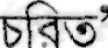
চরিত’
